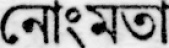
নোংমতা
